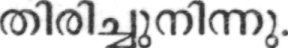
തിരിച്ചുനിന്നു.
